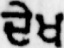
ਦੇਖ
